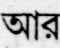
আর
